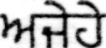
ਅਜੇਹੇ
